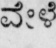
ವೇಳೆ
